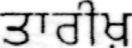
ਤਾਰੀਖ਼
